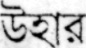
উহার
